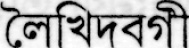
লৈখিদবগী
